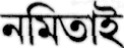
নমিতাই
